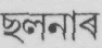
ছলনাৰ
